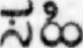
ಸಹಿ
